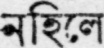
নহিলে
